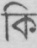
কি
